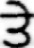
ਤੇ
